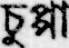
চুপ্পা
